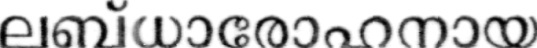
ലബ്ധാരോഹനായ
